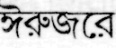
ঈরুজরে
